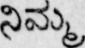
ನಿಮ್ಮ
